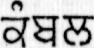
ਕੰਬਲ
